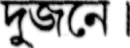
দুজনে।
